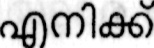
എനിക്ക്
